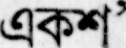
একশ'
